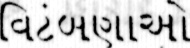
વિટંબણાઓ
